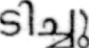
ടിച്ചു
